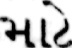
માટે
